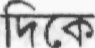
দিকে
